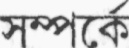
সম্পর্কে
